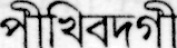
পীখিবদগী
